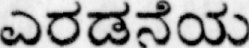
ಎರಡನೆಯ
